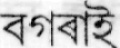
বগৰাই
